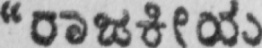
“ರಾಜಕೀಯ
